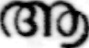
ആ
